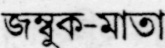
জম্বুক-মাতা
